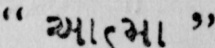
“આત્મા”
